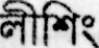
লীশিং
